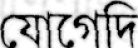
যোগেদি
